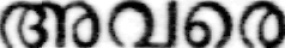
അവരെ
